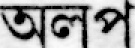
অলপ
